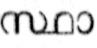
സ്ഥാ
